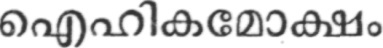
ഐഹികമോക്ഷം
